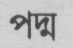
পদ্ম
